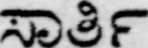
ಸಾರ್ತಿ
